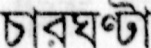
চারঘণ্টা
